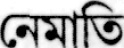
নেমাতি
